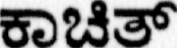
ಕಾಚಿತ್
